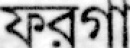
ফরগা
